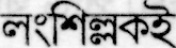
লংশিল্লকই
